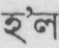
হ'ল
